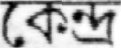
কেন্দ্র
